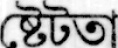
ষ্টেটতা
